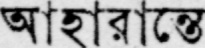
আহারান্তে
